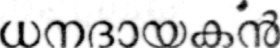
ധനദായകന്‍
